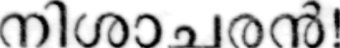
നിശാചരന്‍!
